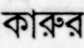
কারুর
